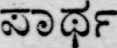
ಪಾರ್ಥ
